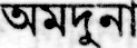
অমদুনা
